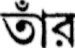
তাঁর
